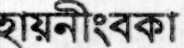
হায়নীংবকা
